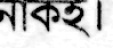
নোকই
